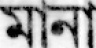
মানা
